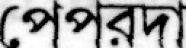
পেপরদা
